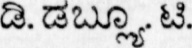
ಡಿ.ಡಬ್ಲ್ಯೂ.ಟಿ.
